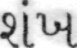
શંખ
